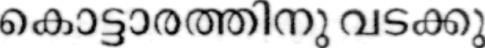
കൊട്ടാരത്തിനുവടക്കു
